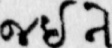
જઈને
